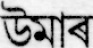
উমাৰ
